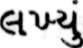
લખ્યું
